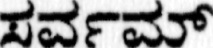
ಸರ್ವಮ್
